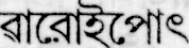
ৱারোইপোৎ
